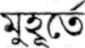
মুহূর্তে
